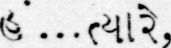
હં....ત્યારે,
